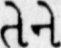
તેને
